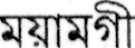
ময়ামগী
